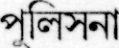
পুলিসনা
